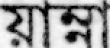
য়াম্না
